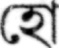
হো
